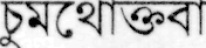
চুমথোক্তবা
